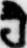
ਹੈ
